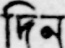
দিন
